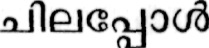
ചിലപ്പോള്‍
